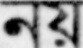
নয়
